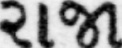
રાજા
